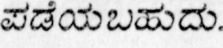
ಪಡೆಯಬಹುದು.
